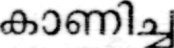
കാണിച്ച
